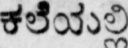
ಕಲೆಯಲ್ಲಿ
